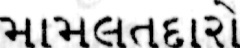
મામલતદારો
